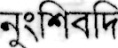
নুংশিবদি
